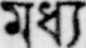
মধ্য
